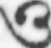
ও
